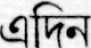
এদিন
